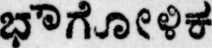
ಭೌಗೋಳಿಕ
